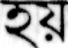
হয়
